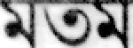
মতম
